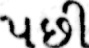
પછી
